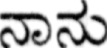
ನಾನು
